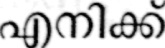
എനിക്ക്
